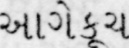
આગેકૂચ
